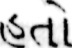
હતો
